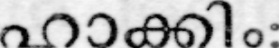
ഹാക്കിം:
